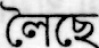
লৈছে
